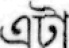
এটা
